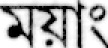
ময়াং
